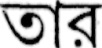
তার
